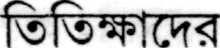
তিতিক্ষাদের
